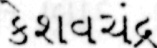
કેશવચંદ્ર
